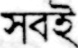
সবই
